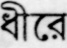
ধীরে
